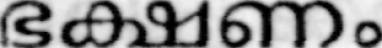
ഭക്ഷണം
